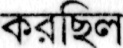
করছিল
